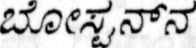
ಬೋಸ್ಟನ್ನ
